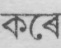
কৰে
